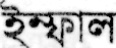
ইম্ফাল
